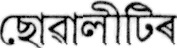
ছোৱালীটিৰ
